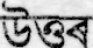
উত্তৰ
